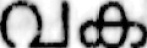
വക
